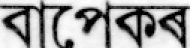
বাপেকৰ
